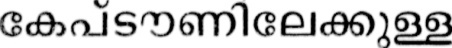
കേപ്ടൌണിലേക്കുള്ള
